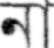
না
